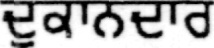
ਦੁਕਾਨਦਾਰ
